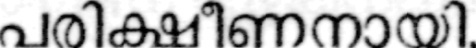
പരിക്ഷീണനായി.
